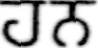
ਹਨ
